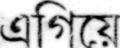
এগিয়ে
